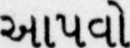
આપવો
